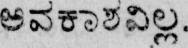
ಅವಕಾಶವಿಲ್ಲ.
